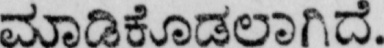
ಮಾಡಿಕೊಡಲಾಗಿದೆ.
